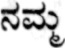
ನಮ್ಮ
